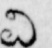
ವಿ
